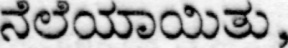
ನೆಲೆಯಾಯಿತು,
